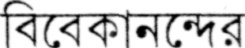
বিবেকানন্দের
